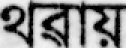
থৱায়
